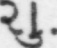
રાુ.
